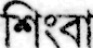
শিংবা
